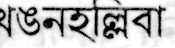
খঙনহল্লিবা
